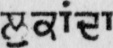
ਲੁਕਾਂਦਾ
